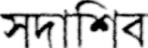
সদাশিব
